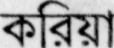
করিয়া
